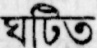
ঘটিত
